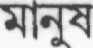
মানুষ
